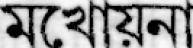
মখোয়না
